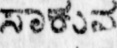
ಸಾಕುವ
